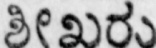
ಶೀಖರು
